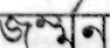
জর্ম্মন
